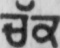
ਚੱਕ
